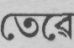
তেৱে
